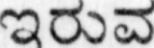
ಇರುವ
